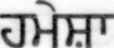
ਹਮੇਸ਼ਾ
